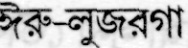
ঈরু-লুজরগা
